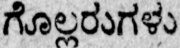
ಗೊಲ್ಲರುಗಳು
